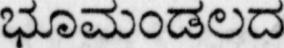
ಭೂಮಂಡಲದ
